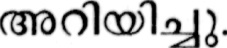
അറിയിച്ചു.
